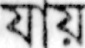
যায়
